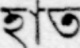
হাত
